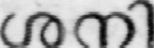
ശനി
